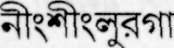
নীংশীংলুরগা
